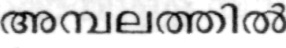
അമ്പലത്തില്‍
